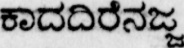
ಕಾದದಿರೆನಜ್ಜ
